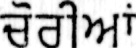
ਚੋਰੀਆਂ
